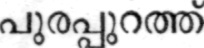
പുരപ്പുറത്ത്
